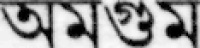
অমগুম
